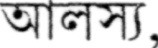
আলস্য,
